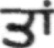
ਤਾਂ
